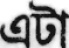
এটা
